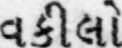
વકીલો
